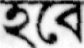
হবে
